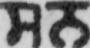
ਸਨ
